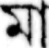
মা
